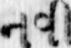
નવી
